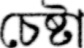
চেষ্টা
